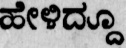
ಹೇಳಿದ್ದೂ
